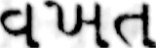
વખત
